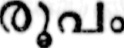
രൂപം
